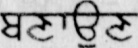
ਬਣਾਉਣ
